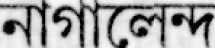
নাগালেন্দ
